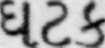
ઘટક
